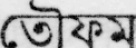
তৌফম
